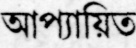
আপ্যায়িত
